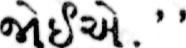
જોઈએ."
